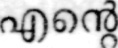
എന്റെ
